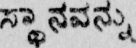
ಸ್ಥಾನವನ್ನು
